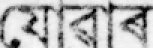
যোৱাৰ
